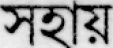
সহায়
